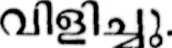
വിളിച്ചു.
